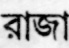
রাজা
